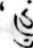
'હું
